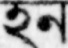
হন
